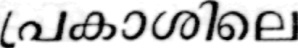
പ്രകാശിലെ
